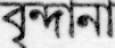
বৃন্দানা
